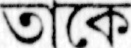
তাকে
